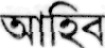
আহিব
